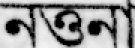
নত্তনা
